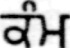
ਕੰਮ
